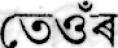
তেওঁৰ
